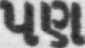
પણ
